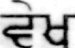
ਵੇਖ
